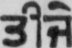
ਤੀਜੇ
